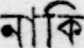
নাকি
